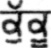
ਕੁੱਕੂ
